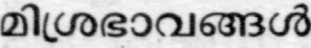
മിശ്രഭാവങ്ങള്‍
